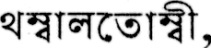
থম্বালতোম্বী,
